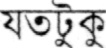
যতটুকু
